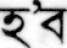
হ'ব
